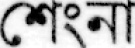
শেংনা
